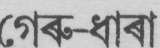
গেৰু-ধাৰা
